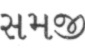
સમજી
